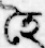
হৈ
